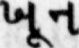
ખૂન
